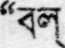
‘‘বল্
